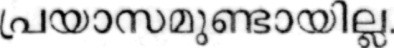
പ്രയാസമുണ്ടായില്ല.
